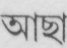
আছা
